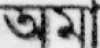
অমা
